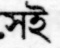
সেই
